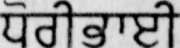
ਧੋਰੀਭਾਈ
